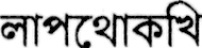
লাপথোকখি
